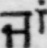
ਜਾਂ
